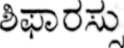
ಶಿಫಾರಸ್ಸು
